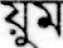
য়ুম
